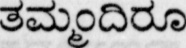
ತಮ್ಮಂದಿರೂ
